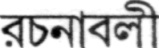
রচনাবলী
